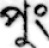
পুং
